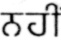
ਨਹੀਂ
